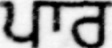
ਪਾਰ
